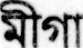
মীগা
